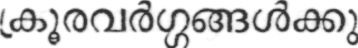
ക്രൂരവര്‍ഗ്ഗങ്ങള്‍ക്കു
